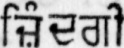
ਜ਼ਿੰਦਗੀ
